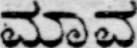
ಮಾವ
